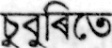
চুবুৰিতে
